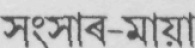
সংসাৰ-মায়া
